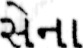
સેના
